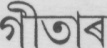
গীতাৰ
